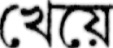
খেয়ে
